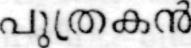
പുത്രകന്‍
